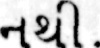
નથી.
